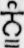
ਨੂੰ
